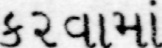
કરવામાં
